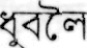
ধুবলৈ
